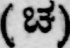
(ಚ)
